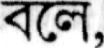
বলে,
